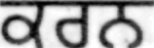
ਕਰਨ
